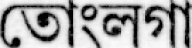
তোংলগা
